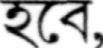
হবে,
